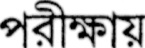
পরীক্ষায়
